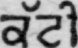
ਕੱਟੀ
